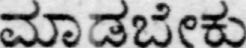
ಮಾಡಬೇಕು
